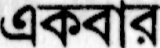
একবার
